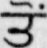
ਤੋਂ
